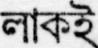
লাকই
